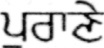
ਪੁਰਾਣੇ
